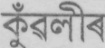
কুঁৱলীৰ
